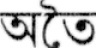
অতৈ
